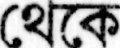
থেকে
